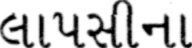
લાપસીના
